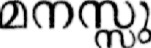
മനസ്സു
